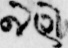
જેણે
